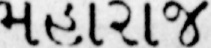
મહારાજ
